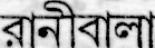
রানীবালা
